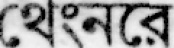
থেংনরে
